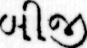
બીજી
